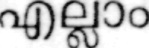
എല്ലാം
